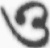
ও
